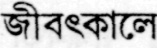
জীবত্কালে
